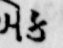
એક
